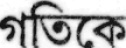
গতিকে
